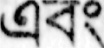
এবং
